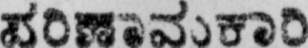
ಪರಿಣಾಮಕಾರಿ
